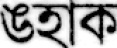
ঙহাক
